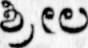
ಶ್ರೀಲ
